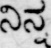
ನಿನ್ನ
